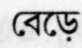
বেড়ে
